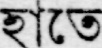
হাতে
